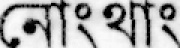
নোংথাং
